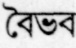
বৈভব
